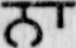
ਨਾ
